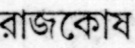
রাজকোষ
